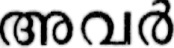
അവര്‍
